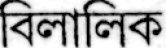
বিলালিক
